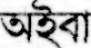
অইবা
